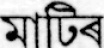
মাটিৰ
